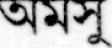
অমসু
